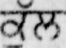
ਕੁੱਲ
